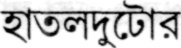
হাতলদুটোর
